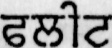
ਫਲੀਟ
